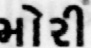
મોરી
